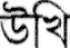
উখি
